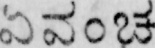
ಏವಂಚ
